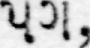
પગ,
